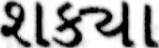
શક્યા
